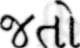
જતો
